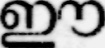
ഈ
